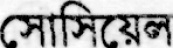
সোসিয়েল
